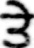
ਤੇ
